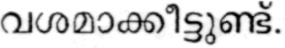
വശമാക്കീട്ടുണ്ട്.
